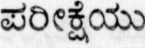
ಪರೀಕ್ಷೆಯು
